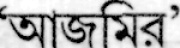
‘আজমির’
